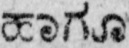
ಹಾಗೂ
